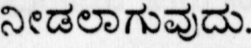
ನೀಡಲಾಗುವುದು.
